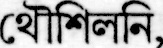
থৌশিলনি,
